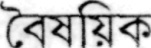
বৈষয়িক
